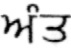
ਅੰਤ
